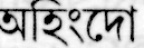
অহিংদো
